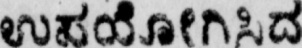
ಉಪಯೋಗಿಸಿದ
